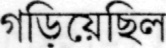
গড়িয়েছিল
